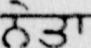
ਨੇਤਾ
